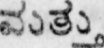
ಮತ್ತು
